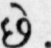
છે.
